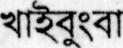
খাইবুংবা
